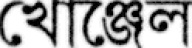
খোঞ্জেল
